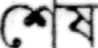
শেষ
